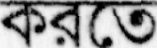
করতে
